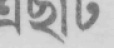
এছাট
